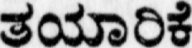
ತಯಾರಿಕೆ
